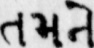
તમને
